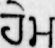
ਹੇਮ
